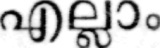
എല്ലാം
